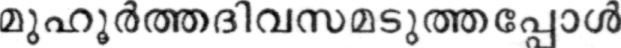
മുഹൂര്‍ത്തദിവസമടുത്തപ്പോള്‍
